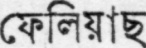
ফেলিয়াছ
